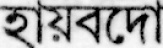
হায়বদো
